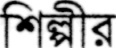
শিল্পীর
